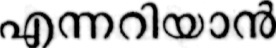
എന്നറിയാന്‍
